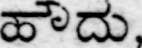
ಹೌದು,
